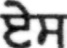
ਏਸ
